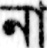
না
